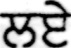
ਲਏ
